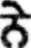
ਨੇ
